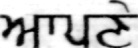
ਆਪਣੇ
